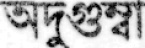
অদুগুম্বা
